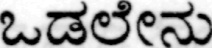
ಒಡಲೇನು
